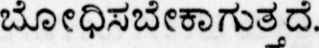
ಬೋಧಿಸಬೇಕಾಗುತ್ತದೆ.
